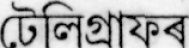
টেলিগ্ৰাফৰ
